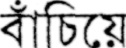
বাঁচিয়ে
